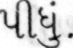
પીધું.
